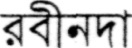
রবীনদা
